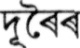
দূৰৈৰ
